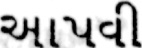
આપવી
